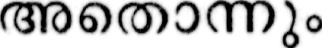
അതൊന്നും
